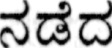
ನಡೆದ
